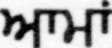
ਆਮਾਂ
